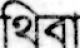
থিবা
